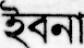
ইবনা
